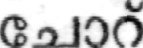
ചോറ്
